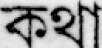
কথা
